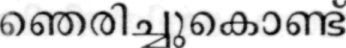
ഞെരിച്ചുകൊണ്ട്
